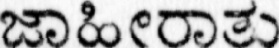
ಜಾಹೀರಾತು
